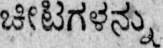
ಚೀಟಿಗಳನ್ನು
